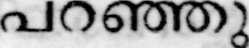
പറഞ്ഞു
